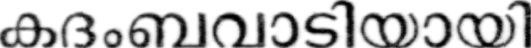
കദംബവാടിയായി
